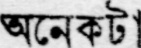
অনেকটা
